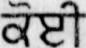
ਕੋਈ
